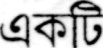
একটি
